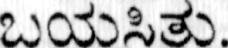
ಬಯಸಿತು.
